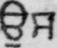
ਉਸ
